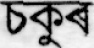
চকুৰ
